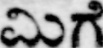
ಮಿಗೆ
